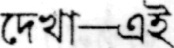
দেখা—এই
